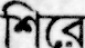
শিরে
